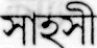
সাহসী
